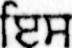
ਇਸ
